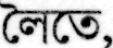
লৈতে,
